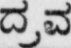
ದ್ರವ
